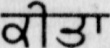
ਕੀਤਾ
